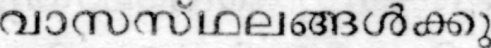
വാസസ്ഥലങ്ങള്‍ക്കു
